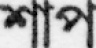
শাপ
